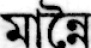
মান্নৈ
